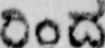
ರಿಂದ
